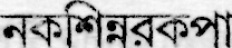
নকশিন্নরকপা
